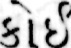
કોઈ
